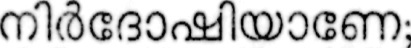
നിര്‍ദോഷിയാണേ;
